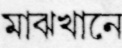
মাঝখানে
